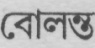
বোলন্ত
